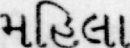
મહિલા
